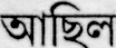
আছিল
